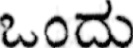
ಒಂದು
